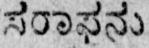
ಸರಾಫನು
